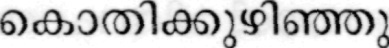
കൊതിക്കുഴിഞ്ഞു
